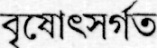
বৃষোৎসর্গত
